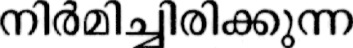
നിര്‍മിച്ചിരിക്കുന്ന
